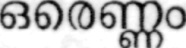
ഒരെണ്ണം
